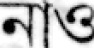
নাও
